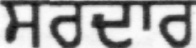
ਸਰਦਾਰ
